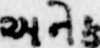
અનેક
